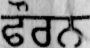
ਫੌਰਨ
